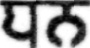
ਧਨ
